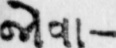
જોવા-
